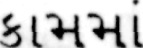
કામમાં
